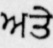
ਅਤੇ
